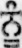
ਨੂੰ
